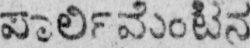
ಪಾರ್ಲಿಮೆಂಟಿನ
